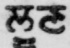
ਲੂਣ
